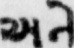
અને
